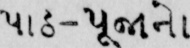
પાઠ-પૂજાનો
